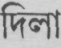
দিলা
